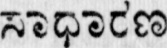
ಸಾಧಾರಣ
